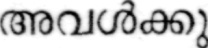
അവള്‍ക്കു
